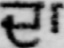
ਦਾ
